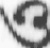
ও
